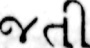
જતી
